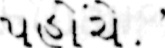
પહોંચે.'
